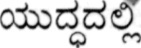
ಯುದ್ಧದಲ್ಲಿ
